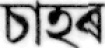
চাহৰ
